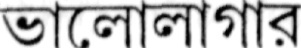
ভালোলাগার
